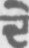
ਦੇ
